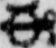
ಈ
